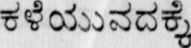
ಕಳೆಯುವದಕ್ಕೆ
